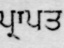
ਪ੍ਰਾਪਤ
